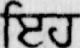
ਇਹ
